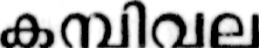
കമ്പിവല
